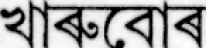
খাৰুবোৰ
